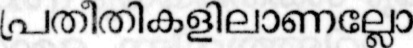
പ്രതീതികളിലാണല്ലോ
